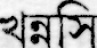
খন্নসি
